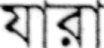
যারা
